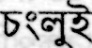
চংলুই
